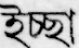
ইচ্ছা
